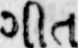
ગીત
